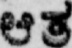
ಆತ
